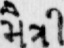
મૈત્રી
